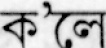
ক'লে
